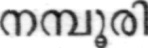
നമ്പൂരി
